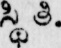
ಸ್ಥಿತಿ.
